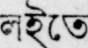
লইতে
